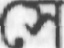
সে
